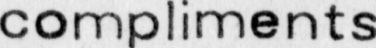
compliments
